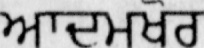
ਆਦਮਖੋਰ
